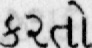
કરતો
